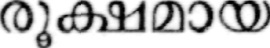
രൂക്ഷമായ
